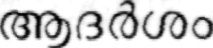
ആദര്‍ശം
